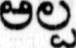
ಅಲ್ಪ
